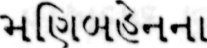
મણિબહેનના
